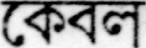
কেবল
